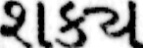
શક્ય
